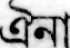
ঐনা
